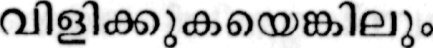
വിളിക്കുകയെങ്കിലും
